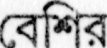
বেশির
